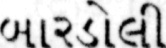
બારડોલી
